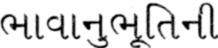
ભાવાનુંભૂતિની
